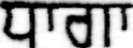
ਧਾਗਾ
